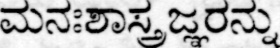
ಮನಃಶಾಸ್ತ್ರಜ್ಞರನ್ನು
